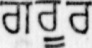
ਗਰੂਰ
